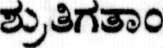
ಶ್ರುತಿಗತಾಂ
